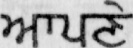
ਆਪਣੇ
